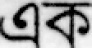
এক
